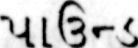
પાઉન્ડ
